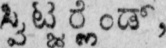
ಸ್ವಿಟ್ಜರ್‍ಲೆಂಡ್,
